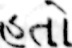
હતો
